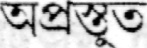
অপ্রস্তুত
